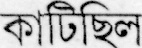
কাটিছিল
